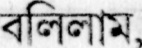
বলিলাম,
